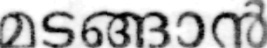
മടങ്ങാന്‍
